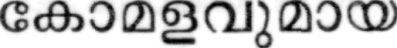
കോമളവുമായ
